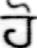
ਹੋ
